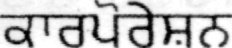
ਕਾਰਪੋਰੇਸ਼ਨ
